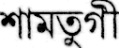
শামতুগী
